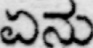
ಏನು
